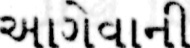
આગેવાની
